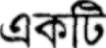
একটি
